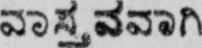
ವಾಸ್ತವವಾಗಿ
